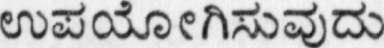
ಉಪಯೋಗಿಸುವುದು
